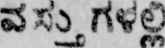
ವಸ್ತುಗಳಲ್ಲಿ
